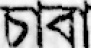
চাবা
